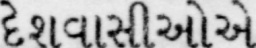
દેશવાસીઓએ
